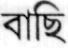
বাছি
